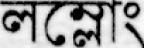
লম্লোং
